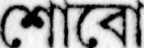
শোবো
